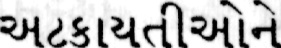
અટકાયતીઓને
